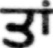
ਤਾਂ
